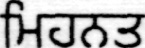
ਮਿਹਨਤ
